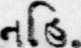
નહિ.
